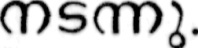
നടന്നു.
